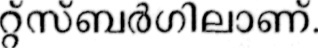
റ്റ്സ്ബര്‍ഗിലാണ്.
